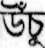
উঁচু
